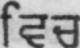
ਵਿਚ
